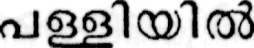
പള്ളിയില്‍
